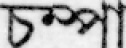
চম্পা
